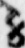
કે
